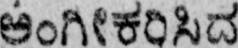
ಅಂಗೀಕರಿಸಿದ
